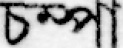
চম্পা
